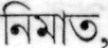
নিমাত,
